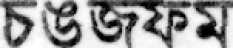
চঙজফম
